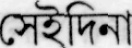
সেইদিনা
